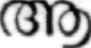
ആ
